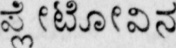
ಪ್ಲೇಟೋವಿನ
